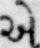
એ
